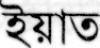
ইয়াত
